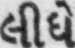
લીધે
